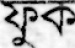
ফুক
